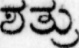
ಶತ್ರು
